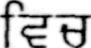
ਵਿਚ
